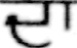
ਦਾ
